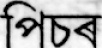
পিচৰ
